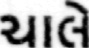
ચાલે
